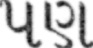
પણ
